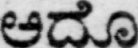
ಅದೊ
